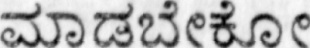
ಮಾಡಬೇಕೋ
